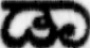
ಡಾ
